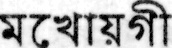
মখোয়গী
